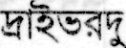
দ্রাইভরদু
